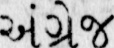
અંગ્રેજ
